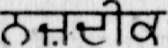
ਨਜ਼ਦੀਕ
